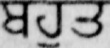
ਬਹੁਤ
